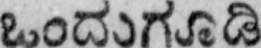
ಒಂದುಗೂಡಿ
